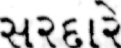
સરદારે
